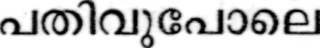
പതിവുപോലെ
